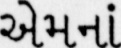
એમનાં
